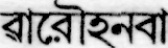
ৱারৌহনবা
